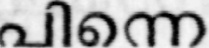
പിന്നെ
